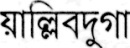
য়াল্লিবদুগা
